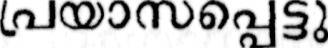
പ്രയാസപ്പെട്ടു
